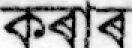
কৰাৰ
